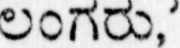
ಲಂಗರು,
